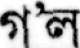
গ'ল
